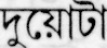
দুয়োটা
